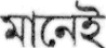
মানেই
